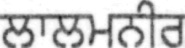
ਲਾਲਮਨੀਰ
